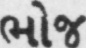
ભોજ
